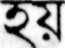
হয়
